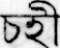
চহী
